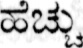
ಹೆಚ್ಚು
